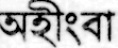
অহীংবা
